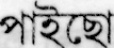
পাইছো
